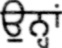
ਉਨ੍ਹਾਂ
